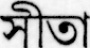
সীতা
